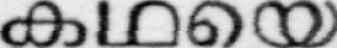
കഥയെ
